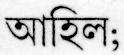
আহিল;
